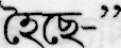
হৈছে-"
